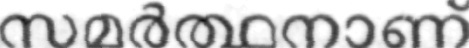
സമര്‍ത്ഥനാണ്
